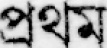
প্রথম
